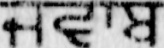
ਜਵਾਬ
